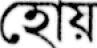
হোয়
